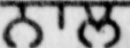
ਨਾਲ
